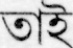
তাই
